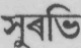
সুৰভি
